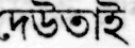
দেউতাই
